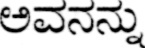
ಅವನನ್ನು
